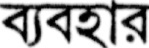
ব্যবহার
